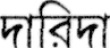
দারিদা
